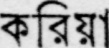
করিয়া
